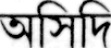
অসিদি
